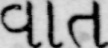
વાત
